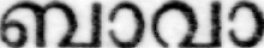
ബാവാ
